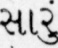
સારું
